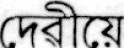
দেৱীয়ে
